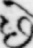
છે
